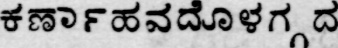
ಕರ್ಣಾಹವದೊಳಗ್ಗದ
